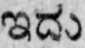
ಇದು
